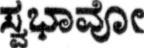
ಸ್ವಭಾವೋ
